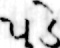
પડે
